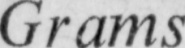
Grams
